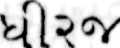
ધીરજ
